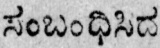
ಸಂಬಂಧಿಸಿದ
